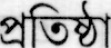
প্রতিষ্ঠা
